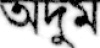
অদুম
